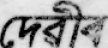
দেৱীব
